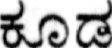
ಕೂಡ
